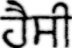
ਹੈਸੀ
